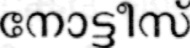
നോട്ടീസ്
